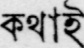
কথাই
